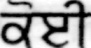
ਕੋਈ
